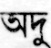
অদু
